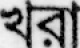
খরা
